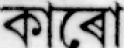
কাৰো
